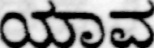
ಯಾವ
